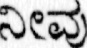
ನೀವು
